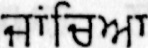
ਜਾਂਚਿਆ
